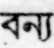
বন্য
